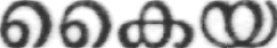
കൈയ
